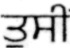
ਤੁਸੀਂ
